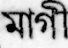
মাগী
